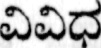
ವಿವಿಧ
